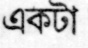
একটা
